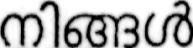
നിങ്ങള്‍
